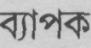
ব্যাপক
